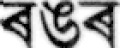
ৰঙৰ
